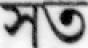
সত
